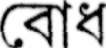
বোধ
